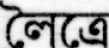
লৈত্রে
